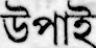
উপাই
